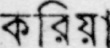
করিয়া
